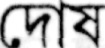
দোষ
